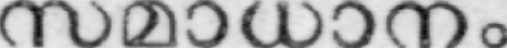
സമാധാനം
